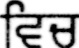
ਵਿਚ
